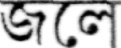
জলে
